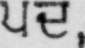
ਪਦ,
